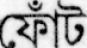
ফোঁট
